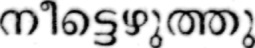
നീട്ടെഴുത്തു
